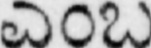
ಎಂಬ
